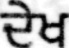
ਦੇਖ
